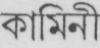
কামিনী
